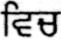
ਵਿਚ
